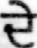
ਦੇ
